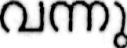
വന്നു
